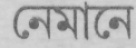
নেমানে
